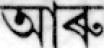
আৰু
